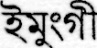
ইমুংগী
